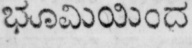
ಭೂಮಿಯಿಂದ
